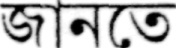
জানতে
